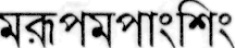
মরূপমপাংশিং
